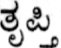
ತೃಪ್ತಿ
